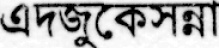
এদজুকেসন্না
